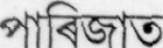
পাৰিজাত
